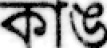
কাঙ
